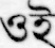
ওই
